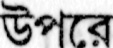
উপরে
